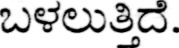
ಬಳಲುತ್ತಿದೆ.
